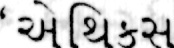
'એથિક્સ
